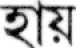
হায়
